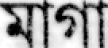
মাগা
